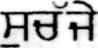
ਸੁਚੱਜੇ
